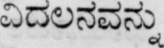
ವಿದಲನವನ್ನು
